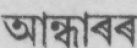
আন্ধাৰৰ
